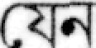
যেন
